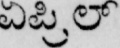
ಏಪ್ರಿಲ್
